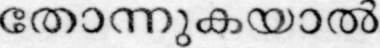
തോന്നുകയാല്‍
